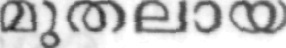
മുതലായ
